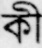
কী
